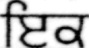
ਇਕ
